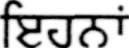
ਇਹਨਾਂ
